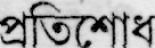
প্রতিশোধ
